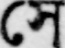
সে
